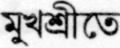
মুখশ্রীতে
